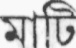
মাটি
